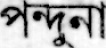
পন্দুনা
